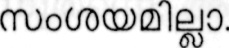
സംശയമില്ലാ.
